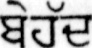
ਬੇਹੱਦ
